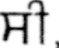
ਸੀ,
